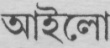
আইলো
